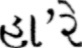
હા`રે
